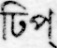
ঢিপ্
